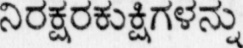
ನಿರಕ್ಷರಕುಕ್ಷಿಗಳನ್ನು
